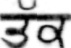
ਤੱਕ
